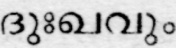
ദുഃഖവും
